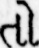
તો
